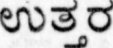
ಉತ್ತರ
